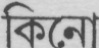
কিনো
